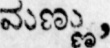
ಮಣ್ಣು,
